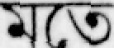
মতে
